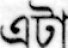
এটা
